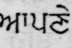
ਆਪਣੇ
